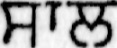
ਸਾਲ
